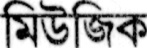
মিউজিক
